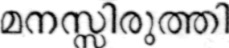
മനസ്സിരുത്തി
